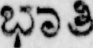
ಭಾತಿ
